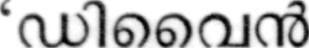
‘ഡിവൈന്‍
